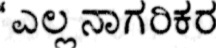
'ಎಲ್ಲನಾಗರಿಕರ
